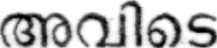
അവിടെ
